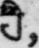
ਹੈ,
